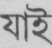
যাই
